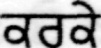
ਕਰਕੇ
